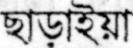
ছাড়াইয়া
